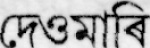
দেওমাৰি
